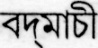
বদ্‌মাচী
